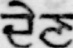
ਦੇਣ
